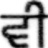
ਵੀ
